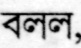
বলল,
